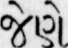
જેણે
